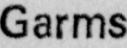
Garms
